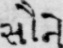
સૌને
